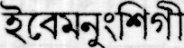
ইবেমনুংশিগী
